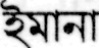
ইমানা
